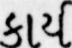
કાર્ય
